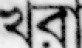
খরা
